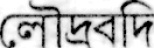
লৌদ্রবদি
